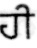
ਹੀ
